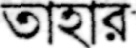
তাহার
